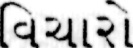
વિચારો
